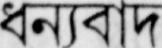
ধন্যবাদ
